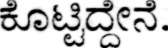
ಕೊಟ್ಟಿದ್ದೇನೆ.
